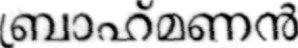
ബ്രാഹ്മണന്‍
